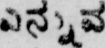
ಎನ್ನುವ
